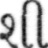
શી
